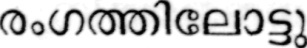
രംഗത്തിലോട്ടു
